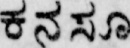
ಕನಸೂ
